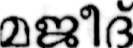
മജീദ്
